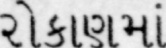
રોકાણમાં
